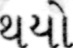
થયો
